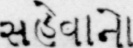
સહેવાનો
